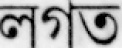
লগত
